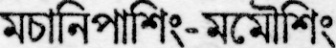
মচানিপাশিং-মমৌশিং
